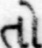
તો
